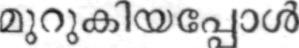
മുറുകിയപ്പോള്‍
